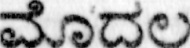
ಮೊದಲ
